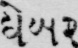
ઘેબર
